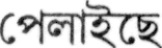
পেলাইছে
